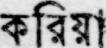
করিয়া
